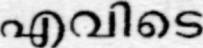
എവിടെ
